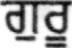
ਗੁਰੂ
